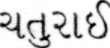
ચતુરાઈ
